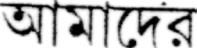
আমাদের
